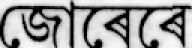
জোৰেৰে
